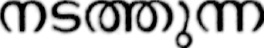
നടത്തുന്ന
